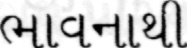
ભાવનાથી
